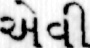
એવી
